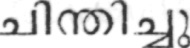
ചിന്തിച്ചു
